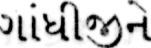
ગાંધીજીને
